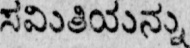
ಸಮಿತಿಯನ್ನು
